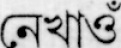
নেখাওঁ
